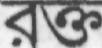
রক্ত
